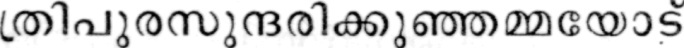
ത്രിപുരസുന്ദരിക്കുഞ്ഞമ്മയോട്
